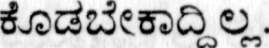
ಕೊಡಬೇಕಾದ್ದಿಲ್ಲ.
